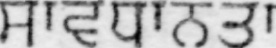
ਸਾਵਧਾਨਤਾ
